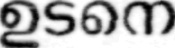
ഉടനെ
